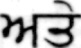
ਅਤੇ
